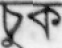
চুক
